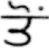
ਤੋਂ
